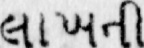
લાખની
